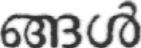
ങ്ങള്‍
